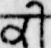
ਕੀ
